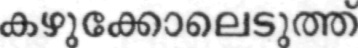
കഴുക്കോലെടുത്ത്
